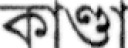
কাণ্ডা
